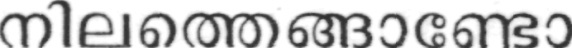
നിലത്തെങ്ങാണ്ടോ
